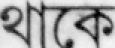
থাকে
